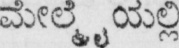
ಮೇಲ್ಮೈಯಲ್ಲಿ
